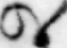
જ
